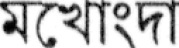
মখোংদা
